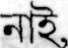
নাই,
